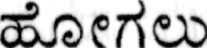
ಹೋಗಲು
